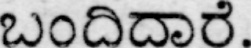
ಬಂದಿದಾರೆ.
